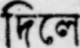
দিলে
